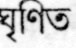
ঘৃণিত
